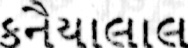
કનૈયાલાલ
